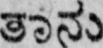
ತಾನು
